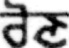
ਰੋਣ
